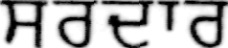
ਸਰਦਾਰ
